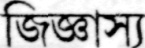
জিজ্ঞাস্য
